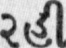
રહી
